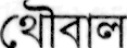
থৌবাল
